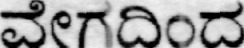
ವೇಗದಿಂದ
